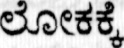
ಲೋಕಕ್ಕೆ
